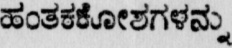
ಹಂತಕೋಶಗಳನ್ನು
